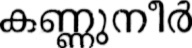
കണ്ണുനീര്‍
